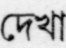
দেখা
